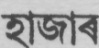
হাজাৰ
